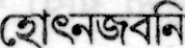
হোৎনজরি
